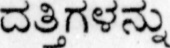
ದತ್ತಿಗಳನ್ನು
